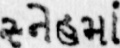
સ્નેહમાં
